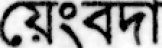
য়েংবদা
